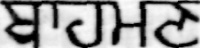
ਬਾਹਮਣ
